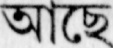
আছে
